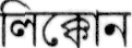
লিক্কোন
